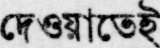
দেওয়াতেই
